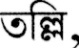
তল্লি,
